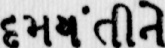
દમયંતીને
